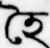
হৈ
